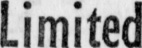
Limited
